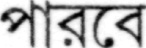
পারবে
